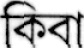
কিবা
